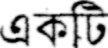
একটি
